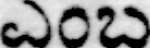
ಎಂಬ
